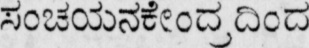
ಸಂಚಯನಕೇಂದ್ರದಿಂದ
